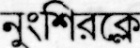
নুংশিরক্লে
